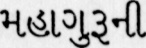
મહાગુરૂની
